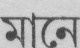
মানে
